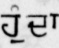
ਹੁੰਦਾ
